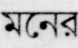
মনের
